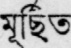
মূর্ছিত
